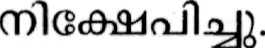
നിക്ഷേപിച്ചു.
